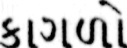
કાગળો
